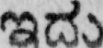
ಇದು
